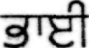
ਭਾਈ
